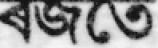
ৰজতে
